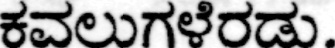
ಕವಲುಗಳೆರಡು.
